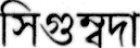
সিগুম্বদা
